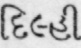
દિલ્હી
